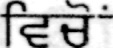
ਵਿਚੋਂ
